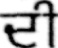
ਦੀ
